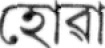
হোৱা
